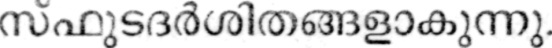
സ്ഫുടദര്‍ശിതങ്ങളാകുന്നു.
